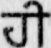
ਹੀ
